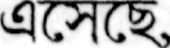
এসেছে,
